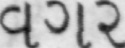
વગર
